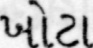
ખોટા
